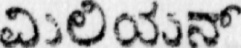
ಮಿಲಿಯನ್
